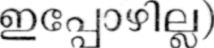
ഇപ്പോഴില്ല)
